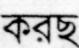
করছ
